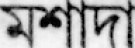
মশাদা
